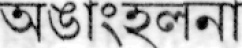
অঙাংহলনা
